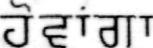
ਹੋਵਾਂਗਾ
